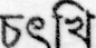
চৎখি
